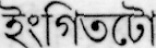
ইংগিতটো
